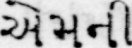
એમની
